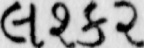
લશ્કર
